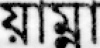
য়াম্না
